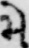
મે
